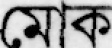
মোক
